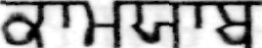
ਕਾਮਯਾਬ
